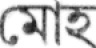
মোহ
